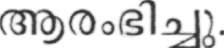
ആരംഭിച്ചു.
